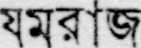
যমরাজ
